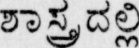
ಶಾಸ್ತ್ರದಲ್ಲಿ
